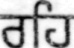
ਰਹਿ
